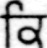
ਕਿ
